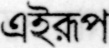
এইরূপ
